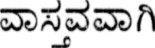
ವಾಸ್ತವವಾಗಿ
